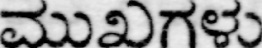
ಮುಖಗಳು
